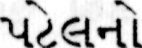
પટેલનો
